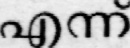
എന്ന്
